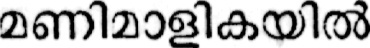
മണിമാളികയില്‍
